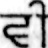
ਵੀ
